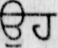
ਉਹ
